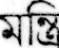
মন্ত্রি
